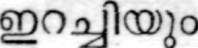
ഇറച്ചിയും
